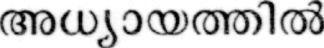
അധ്യായത്തില്‍
